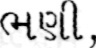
ભણી,
